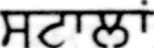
ਸਟਾਲਾਂ
